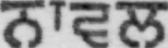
ਨਾਵਲ
